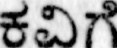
ಕವಿಗೆ
